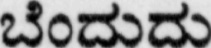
ಬೆಂದುದು
